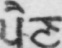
ਪੈਣ
